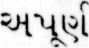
અપૂર્ણ
